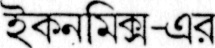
ইকনমিক্স-এর
